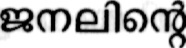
ജനലിന്റെ
